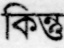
কিন্তু
